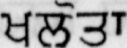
ਖਲੋਤਾ
